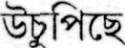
উচুপিছে
